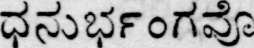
ಧನುರ್ಭಂಗವೊ
